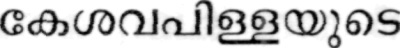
കേശവപിള്ളയുടെ
